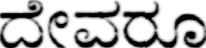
ದೇವರೂ
